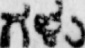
ಗಳು
